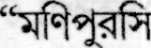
“মণিপুরসি
